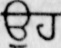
ਉਹ
